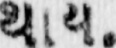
થાય.
